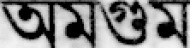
অমগুম
